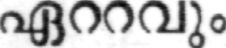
ഏററവും
